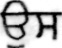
ਉਸ
